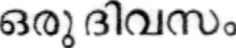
ഒരുദിവസം
